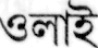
ওলাই
